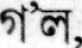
গ'ল,
